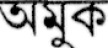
অমুক
